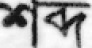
শব্দ
